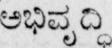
ಅಭಿವೃದ್ಧಿ
